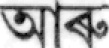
আৰু
